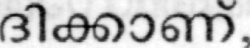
ദിക്കാണ്,
